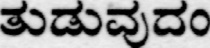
ತುಡುವುದಂ
